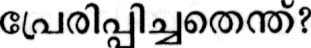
പ്രേരിപ്പിച്ചതെന്ത്?
